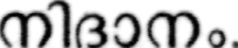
നിദാനം.
